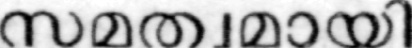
സമത്വമായി
